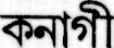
কনাগী
